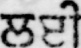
ਲਈ
